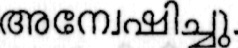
അന്വേഷിച്ചു.
